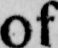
of
